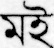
মই
